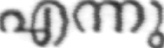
എന്നു
